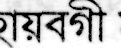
হায়বগী
